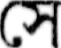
সে
